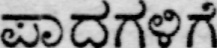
ಪಾದಗಳಿಗೆ
